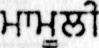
ਮਾਮੂਲੀ
